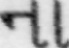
ના
